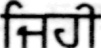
ਜਿਹੀ
